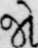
જો
